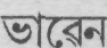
ভাৱেন
